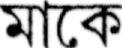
মাকে
